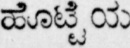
ಹೊಟ್ಟೆಯ
